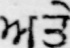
ਅਤੇ
